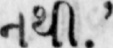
નથી.'
